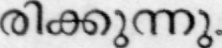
രിക്കുന്നു.
